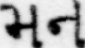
મન
